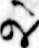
જે
